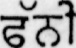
ਫੱਨੀ
